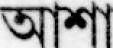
আশা
